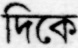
দিকে
